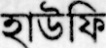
হাউফি
